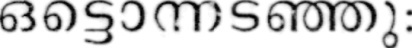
ഒട്ടൊന്നടഞ്ഞു:
